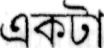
একটা
